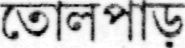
তোলপাড়
